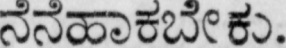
ನೆನೆಹಾಕಬೇಕು.
